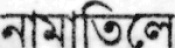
নামাতিলে
